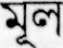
মূল
